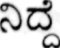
ನಿದ್ದೆ
